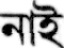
নাই
